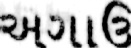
અગાઉ
